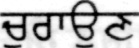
ਚੁਰਾਉਣ
